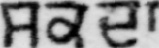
ਸਕਦਾ
